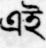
এই
